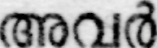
അവര്‍
